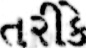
તરીકે
